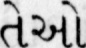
તેઓ
